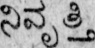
ನಿವೃತ್ತಿ
